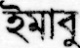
ইমাবু
